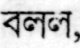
বলল,
